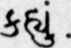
કહ્યું.
